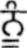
ਨੂੰ
